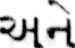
અને
